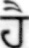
ਹੈ
